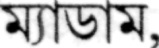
ম্যাডাম,
